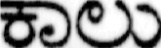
ಕಾಲು
